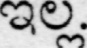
ಇಲ್ಲ.
